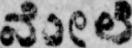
ಮೇಲೆ
